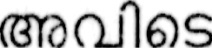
അവിടെ
